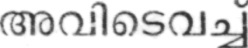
അവിടെവച്ച്
